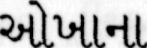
ઓખાના
